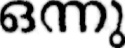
ഒന്നു
